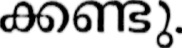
ക്കണ്ടു.
